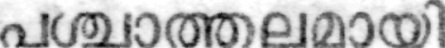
പശ്ചാത്തലമായി
